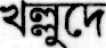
খল্লুদে
